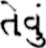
તેવું
